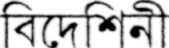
বিদেশিনী
